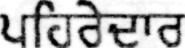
ਪਹਿਰੇਦਾਰ
